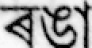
ৰঙা
